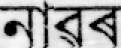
নাৱৰ
